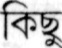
কিছু
